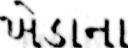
ખેડાના
